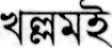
খল্লমই
